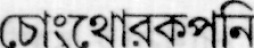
চোংথোরকপনি
